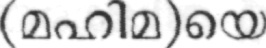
(മഹിമ)യെ
